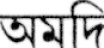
অমদি
